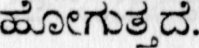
ಹೋಗುತ್ತದೆ.
